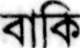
বাকি
